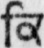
ਕਿ
